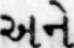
અને
